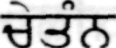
ਚੇਤੰਨ
